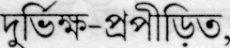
দুর্ভিক্ষ-প্ৰপীড়িত,
